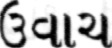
ઉવાચ
